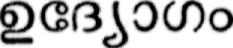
ഉദ്യോഗം
